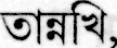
তান্নখি,
